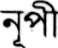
নূপী
